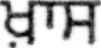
ਖ਼ਾਸ
